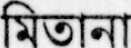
মিতানা
